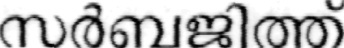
സര്‍ബജിത്ത്
